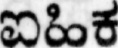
ಐಹಿಕ
